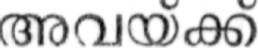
അവയ്ക്ക്
